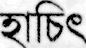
হাচিৎ
